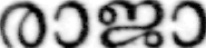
രാജാ
